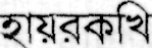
হায়রকখি
